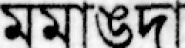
মমাঙদা
